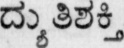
ದ್ಯುತಿಶಕ್ತಿ
